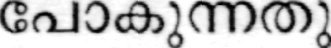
പോകുന്നതു
